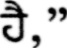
ਹੈ,''
